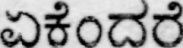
ಏಕೆಂದರೆ
